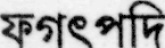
ফগৎপদি
